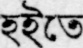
হইতে
